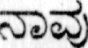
ನಾವು
